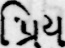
પ્રિય
